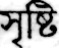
সৃষ্টি
